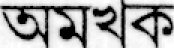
অমখক
